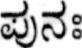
ಪುನಃ
